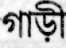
গাড়ী
